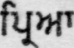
ਪ੍ਰਿਆ
